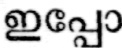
ഇപ്പോ
